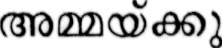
അമ്മയ്ക്കു
